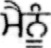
ਮੈਨੂੰ
